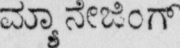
ಮ್ಯಾನೇಜಿಂಗ್
